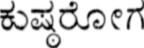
ಕುಷ್ಠರೋಗ
